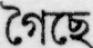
গৈছে
